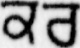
ਕਰ
